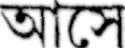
আসে
